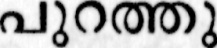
പുറത്തു
